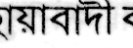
ছায়াবাদী
